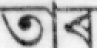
তাৰ
